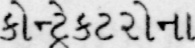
કોન્ટ્રેકટરોના
